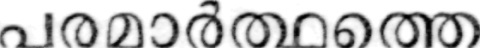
പരമാര്‍ത്ഥത്തെ
